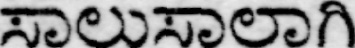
ಸಾಲುಸಾಲಾಗಿ
